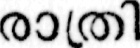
രാത്രി
